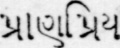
પ્રાણપ્રિય
